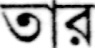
তার
